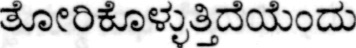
ತೋರಿಕೊಳ್ಳುತ್ತಿದೆಯೆಂದು
